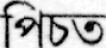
পিচত
